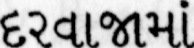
દરવાજામાં
